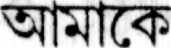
আমাকে
